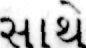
સાથે
